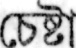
চেষ্টা
